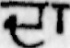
ਦਾ
